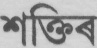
শক্তিৰ
